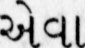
એવા
